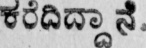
ಕರೆದಿದ್ದಾನೆ.
